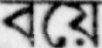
বয়ে
